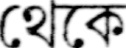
থেকে
